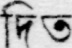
দিত
